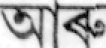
আৰু
